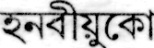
হনবীয়ুকো
